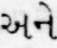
અને
